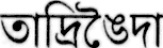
তাদ্রিঙৈদা
